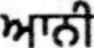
ਆਨੀ
